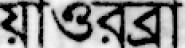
য়াওরব্রা
